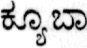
ಕ್ಯೂಬಾ
